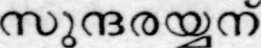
സുന്ദരയ്യന്
